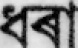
ধৰা
